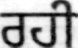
ਰਹੀ
